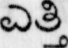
ಎತ್ತಿ
